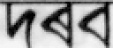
দৰব
